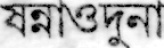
ষন্নাওদুনা
